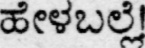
ಹೇಳಬಲ್ಲೆ!
